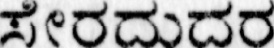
ಸೇರದುದರ
